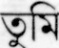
তুমি
